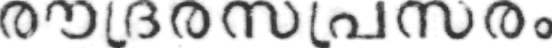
രൌദ്രരസപ്രസരം
